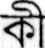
কী
